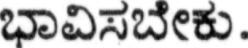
ಭಾವಿಸಬೇಕು.
